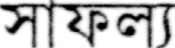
সাফল্য
